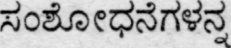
ಸಂಶೋಧನೆಗಳನ್ನ
